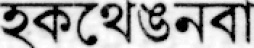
হকথেঙনবা
